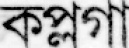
কপ্লগা
